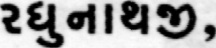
રધુનાથજી,
